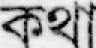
কথা
